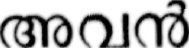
അവന്‍
